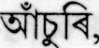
আঁচুৰি,
